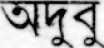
অদুবু
